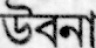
উবনা
